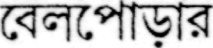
বেলপোড়ার
